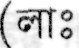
(লাঃ
